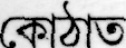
কোঠাত
